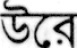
উরে
